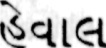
હેવાલ
